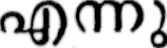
എന്നു
